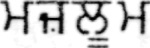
ਮਜ਼ਲੂਮ
